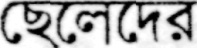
ছেলেদের
